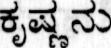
ಕೃಷ್ಣನು
